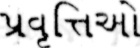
પ્રવૃત્તિઓ
